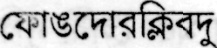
ফোঙদোরক্লিবদু
